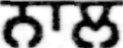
ਨਾਲ
